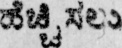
ಹೆಚ್ಚಿಸಲು
